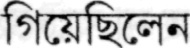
গিয়েছিলেন
